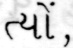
ત્યોં,
